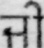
ਜੀ
